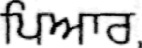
ਪਿਆਰ,
